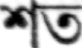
শত
